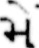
મેં
